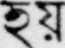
হয়
